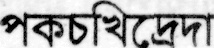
পকচখিদ্রেদা
